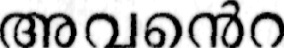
അവന്റെ
